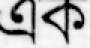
এক
